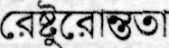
রেষ্টুরোন্ততা
